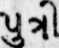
પુત્રી
